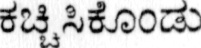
ಕಚ್ಚಿಸಿಕೊಂಡು
